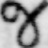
જ
